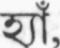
হ্যাঁ,
